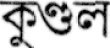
কুণ্ডল
